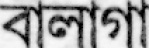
বালাগা
